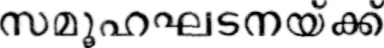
സമൂഹഘടനയ്ക്ക്
